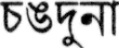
চঙদুনা
